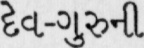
દેવ-ગુરુની
